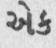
એક
